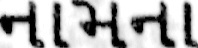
નામના
